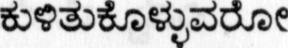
ಕುಳಿತುಕೊಳ್ಳುವರೋ
